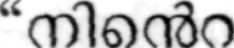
"നിന്റെ
